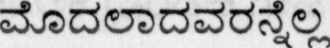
ಮೊದಲಾದವರನ್ನೆಲ್ಲ
